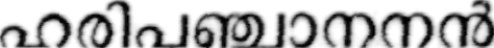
ഹരിപഞ്ചാനനന്‍
